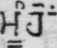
ਮੂੰਹੋਂ
